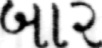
બાર
